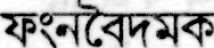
ফংনবৈদমক
